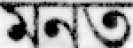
মনত
